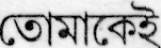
তোমাকেই
